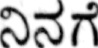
ನಿನಗೆ
